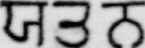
ਯਤਨ
